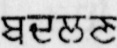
ਬਦਲਣ
